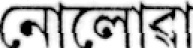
নোলোৱা
